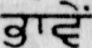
ਭਾਵੇਂ
